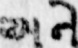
અને
